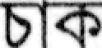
চাক
